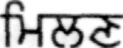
ਮਿਲਣ
